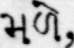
મળે,
